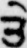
ਤੇ
